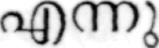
എന്നു
